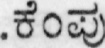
ಕೆಂಪು
